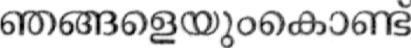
ഞങ്ങളെയുംകൊണ്ട്
